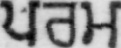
ਪਰਮ
